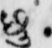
છું.
